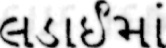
લડાઇમાં
